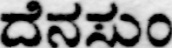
ದೆನಸುಂ
